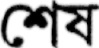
শেষ
